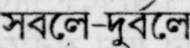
সবলে-দুর্বলে
